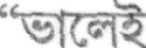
"ভালেই
